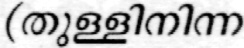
(തുള്ളിനിന്ന
